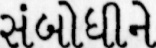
સંબોધીને
